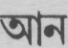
আন
